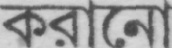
করানো
